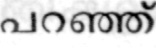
പറഞ്ഞ്
